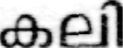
കലി
